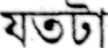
যতটা
